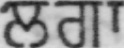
ਲਗਾ
